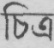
চিত্ৰ
